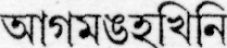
আগমঙহখিনি
